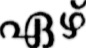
ഏഴ്
